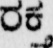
ರಕ್ತ
